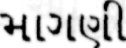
માગણી
